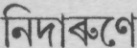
নিদাৰুণে
